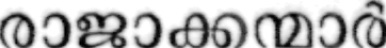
രാജാക്കന്മാര്‍
